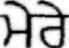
ਮੇਰੇ
